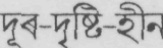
দূৰ-দৃষ্টি-হীন
